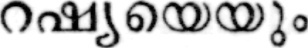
റഷ്യയെയും
